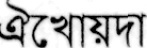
ঐখোয়দা
